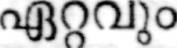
ഏറ്റവും
